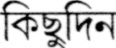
কিছুদিন
